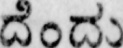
ದೆಂದು
